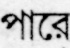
পারে
